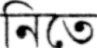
নিতে
